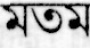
মতম
